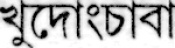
খুদোংচাবা
